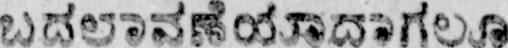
ಬದಲಾವಣೆಯಾದಾಗಲೂ
